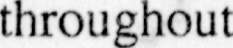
throughout
